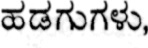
ಹಡಗುಗಳು,
